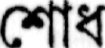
শোধ
